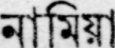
নামিয়া
